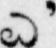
ಎ’
